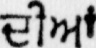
ਦੀਆਂ
